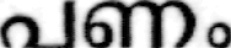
പണം
